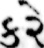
કરે
